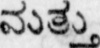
ಮತ್ತು
